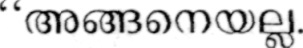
"അങ്ങനെയല്ല.
